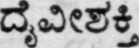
ದೈವೀಶಕ್ತಿ
